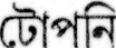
টোপনি
